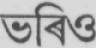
ভৰিও
